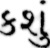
કશું
